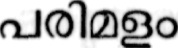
പരിമളം
